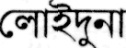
লোইদুনা
